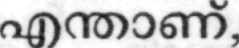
എന്താണ്,
